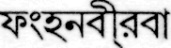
ফংহনবীরবা
